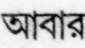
আবার
